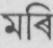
মৰি
